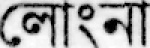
লোংনা
